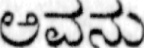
ಅವನು
